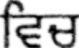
ਵਿਚ
